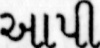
આપી
